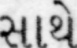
સાથે
